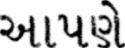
આપણે
